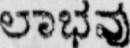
ಲಾಭವು
